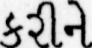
કરીને
